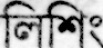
লিশিং
